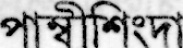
পাম্বীশিংদা
